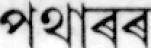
পথাৰৰ
